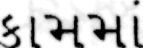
કામમાં
